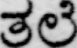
ತಲೆ
